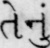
તેનું
